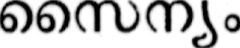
സൈന്യം
